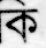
কি
